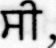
ਸੀ,
